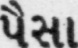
પૈસા
